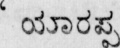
‘ಯಾರಪ್ಪ
